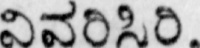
ವಿವರಿಸಿರಿ.
